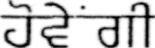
ਹੋਵੇਂਗੀ
